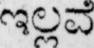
ಇಲ್ಲವೆ
